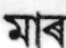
মাৰ
